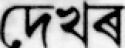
দেখৰ
